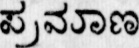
ಪ್ರಮಾಣ
